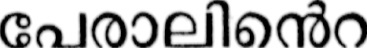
പേരാലിന്റെ
